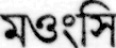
মওংসি
